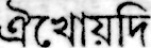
ঐখোয়দি
